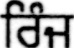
ਰਿੰਜ
